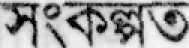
সংকল্পত
